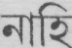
নাহি
